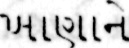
ખાણાને
